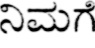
ನಿಮಗೆ
